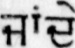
ਜਾਂਦੇ
